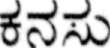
ಕನಸು
